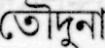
তৌদুনা
